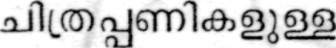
ചിത്രപ്പണികളുള്ള
